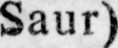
Saur)
